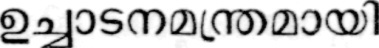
ഉച്ചാടനമന്ത്രമായി
